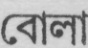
বোলা
